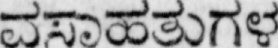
ವಸಾಹತುಗಳ
